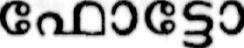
ഫോട്ടോ
